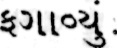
ફગાવ્યું.
